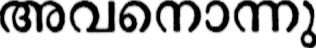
അവനൊന്നു
